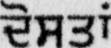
ਦੋਸਤਾਂ
